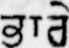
ਭਾਰੇ
